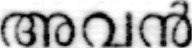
അവന്‍
